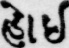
હોઈ
